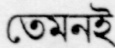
তেমনই
